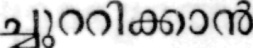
ച്ചുററിക്കാന്‍
